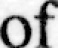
of
